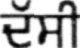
ਦੱਸੀ
